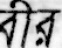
বীর
